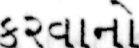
કરવાનો
